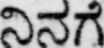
ನಿನಗೆ
